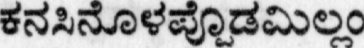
ಕನಸಿನೊಳಪ್ಪೊಡಮಿಲ್ಲಂ
